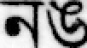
নঙ
